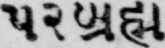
પરબ્રહ્મ
